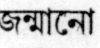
জন্মানো
